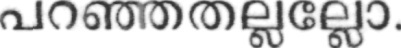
പറഞ്ഞതല്ലല്ലോ.
